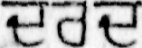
ਦਰਦ
